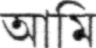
আমি
